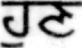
ਹੁਣ
